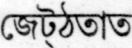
জেট্ঠতাত
